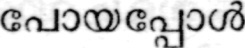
പോയപ്പോള്‍
